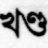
খণ্ড
